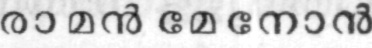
രാമന്‍മേനോന്‍
